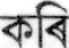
কৰি
